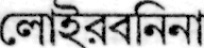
লোইরবনিনা
